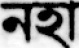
নহা
